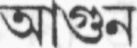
আগুন
